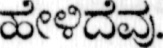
ಹೇಳಿದೆವು.
